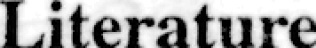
Literature
